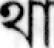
থা
